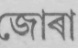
জোৰা
